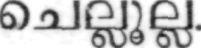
ചെല്ലൂല്ല.
